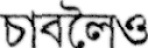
চাবলৈও
